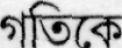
গতিকে
